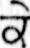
ਕੇ
